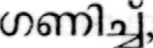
ഗണിച്ച്,
